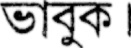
ভাবুক।
